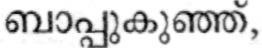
ബാപ്പുകുഞ്ഞ്,
